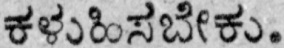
ಕಳುಹಿಸಬೇಕು.
